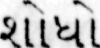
શોધો
